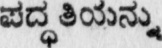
ಪದ್ಧತಿಯನ್ನು
